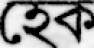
হেক
